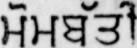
ਮੋਮਬੱਤੀ
